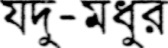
যদু-মধুর
